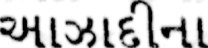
આઝાદીના
